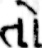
તો
